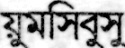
য়ুমসিবুসু
